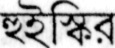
হুইস্কির
